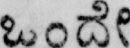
ಒಂದೇ
